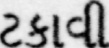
ટકાવી
